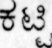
ಕಟ್ಟಿ
